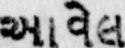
આવેલ
